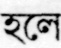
হলে
